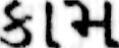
કામ
